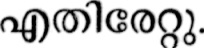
എതിരേറ്റു.
